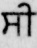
ਸੀ
